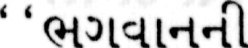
"ભગવાનની
